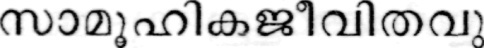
സാമൂഹികജീവിതവു
